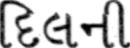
દિલની
